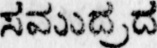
ಸಮುದ್ರದ
